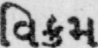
વિક્રમ
